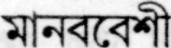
মানববেশী
